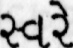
સ્વરે
